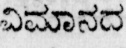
ವಿಮಾನದ
